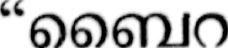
“ബൈറ
